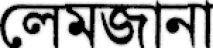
লেমজানা
